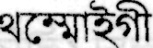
থম্মোইগী
